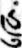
હું
